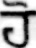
ਹੋ
